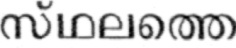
സ്ഥലത്തെ
